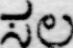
ಸಲ
